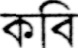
কবি
